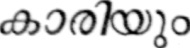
കാരിയും
